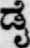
ಡೈ
